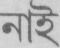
নাই
